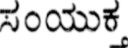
ಸಂಯುಕ್ತ
